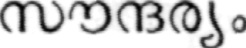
സൌന്ദര്യം
